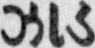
ઝાડ
